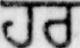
ਹਰ
